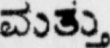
ಮತ್ತು
